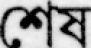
শেষ
